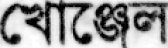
খোঞ্জেল
